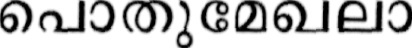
പൊതുമേഖലാ
